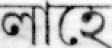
লাহে
